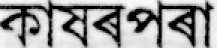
কাষৰপৰা
